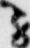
કે
